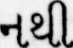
નથી
